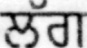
ਲੱਗ
